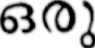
ഒരു
